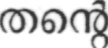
തന്റെ
